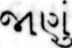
જાણું
